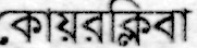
কোয়রক্লিবা
